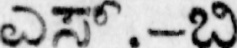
ಎಸ್.-ಬಿ
